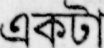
একটা
